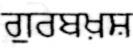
ਗੁਰਬਖ਼ਸ਼
